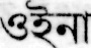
ওইনা
